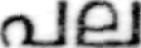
പല
